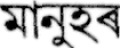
মানুহৰ
